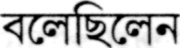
বলেছিলেন
